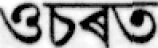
ওচৰত
